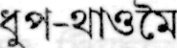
ধুপ-থাওমৈ
